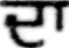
ਦਾ
